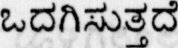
ಒದಗಿಸುತ್ತದೆ
